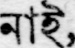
নাই,
